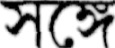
সঙ্গে
